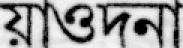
য়াওদনা
